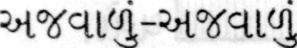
અજવાળું-અજવાળું
